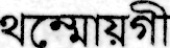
থম্মোয়গী
